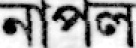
নাপল
